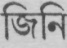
জিনি
